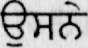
ਉਸਨੇ
